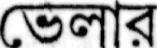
ভেলার
